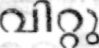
വിറ്റു
